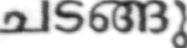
ചടങ്ങു
